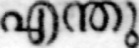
എന്തു
